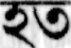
হত
